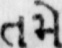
તમે
